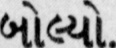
બોલ્યો.
